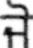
ਜੋ
